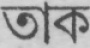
তাক
